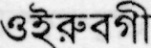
ওইরুবগী
